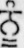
ਨੂੰ
